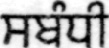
ਸਬੰਧੀ
